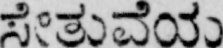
ಸೇತುವೆಯ
